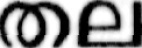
തല
